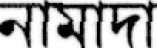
নামাদা
